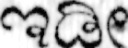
ಇಡೀ
